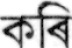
কৰি
